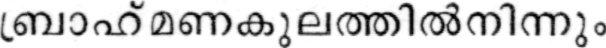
ബ്രാഹ്മണകുലത്തില്‍നിന്നും
